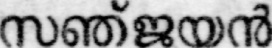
സഞ്ജയന്‍
